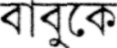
বাবুকে
